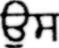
ਉਸ
